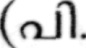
(പി.
